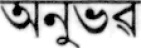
অনুভৱ
